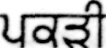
ਪਕੜੀ
